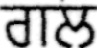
ਗਲ
